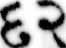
દર
